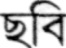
ছবি
